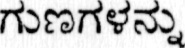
ಗುಣಗಳನ್ನು
